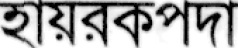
হায়রকপদা
